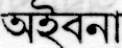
অইবনা
